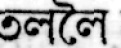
তললৈ
